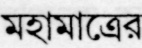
মহামাত্রের
